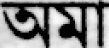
অমা
